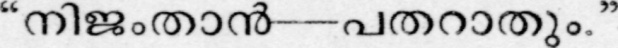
"നിജംതാന്‍-പതറാതും."
